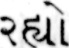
રહ્યો
